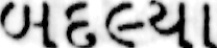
બદલ્યા
